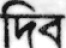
দিব
